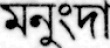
মনুংদা
